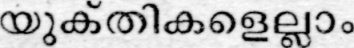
യുക്തികളെല്ലാം
